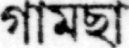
গামছা
